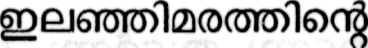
ഇലഞ്ഞിമരത്തിന്റെ
